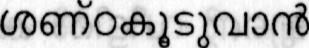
ശണ്ഠകൂടുവാന്‍
